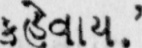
કહેવાય.'
